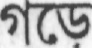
গড়ে
